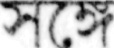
সঙ্গে
